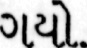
ગયો.
